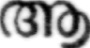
ആ
